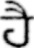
ਹੈ
